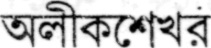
অলীকশেখর
